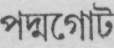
পদ্মগোট
